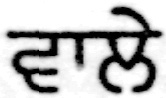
ਵਾਲੇ
